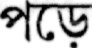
পড়ে
